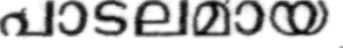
പാടലമായ
